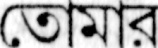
তোমার
